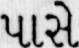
પાસે
